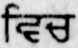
ਵਿਚ
